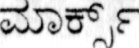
ಮಾರ್ಕ್ಸ್
